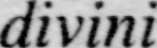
divini
